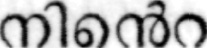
നിന്റെ
